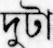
দুটা
